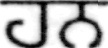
ਹਨ
